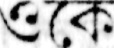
ওকে
